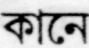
কানে
